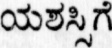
ಯಶಸ್ಸಿಗೆ
